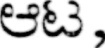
ಆಟ,
